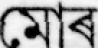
মোৰ
